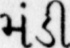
મંડી
